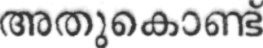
അതുകൊണ്ട്
